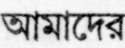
আমাদের
